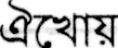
ঐখোয়
